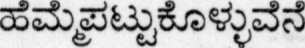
ಹೆಮ್ಮೆಪಟ್ಟುಕೊಳ್ಳುವೆನೆ
